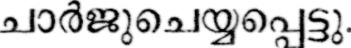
ചാര്‍ജുചെയ്യപ്പെട്ടു.
